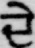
ਦੇ
